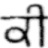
ਕੀ
